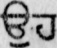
ਉਹ
